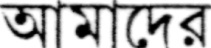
আমাদের
